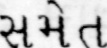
સમેત
